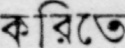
করিতে
